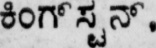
ಕಿಂಗ್‌ಸ್ಟನ್,
